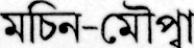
মচিন-মৌপ্বা
